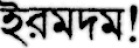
ইরমদম!
